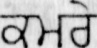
ਕਮਰੇ
